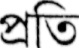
প্রতি
